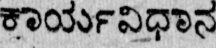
ಕಾರ್ಯವಿಧಾನ
